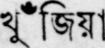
খুঁজিয়া
